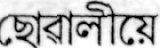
ছোৱালীয়ে
